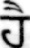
ਹੈ
